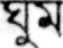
ঘুম
